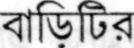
বাড়িটির
